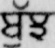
ਬੁੱਝ
